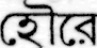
হৌরে
